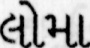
લોમા
